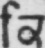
ਕਿ
